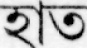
হাত
